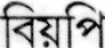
বিয়পি
